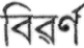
বিৱর্ণ
